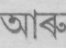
আৰু
